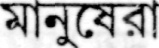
মানুষেরা
